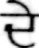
ਦੇ
